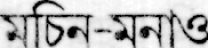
মচিন-মনাও
